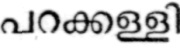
പറക്കള്ളി
